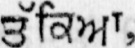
ਤੱਕਿਆ,
